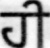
ਹੀ
